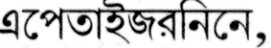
এপেতাইজরনিনে,
